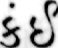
કંઇ
